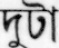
দুটা
